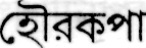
হৌরকপা
